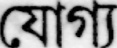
যোগ্য
